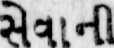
સેવાની
